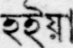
হইয়া
